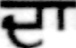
ਦਾ
